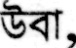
উবা,
